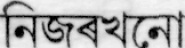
নিজৰখনো
